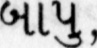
બાપુ,
